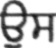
ਉਸ
